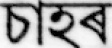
চাহৰ
